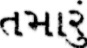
તમારું
